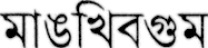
মাঙখিবগুম
